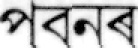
পবনৰ
